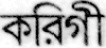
করিগী
